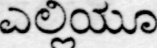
ಎಲ್ಲಿಯೂ
